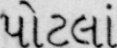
પોટલાં
